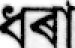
ধৰা
